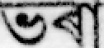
ভৰা
